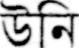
উনি
